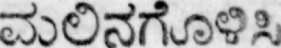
ಮಲಿನಗೊಳಿಸಿ
